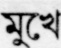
মুখে
